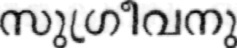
സുഗ്രീവനു
